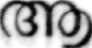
ആ
